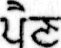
ਪੈਣ
